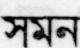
সমন
